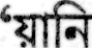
‘য়ানি
